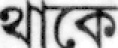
থাকে
